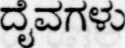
ದೈವಗಳು
